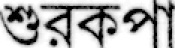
শুরকপা
